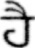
ਹੈ
